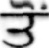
ਤੋਂ
